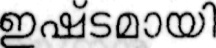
ഇഷ്ടമായി
